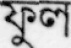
ফুল
